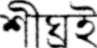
শীঘ্রই
